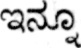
ಇನ್ನೂ
